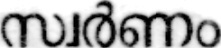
സ്വര്‍ണം
